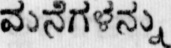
ಮನೆಗಳನ್ನು
